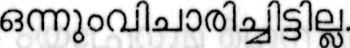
ഒന്നുംവിചാരിച്ചിട്ടില്ല.
